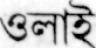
ওলাই
